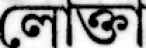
লোক্তা
